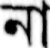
না
